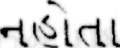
નહોતા
